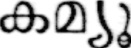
കമ്യൂ
